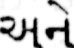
અને
